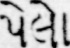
પેલો
